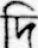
দি
